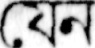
যেন
